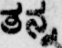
ತನ್ನ
